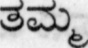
ತಮ್ಮ
